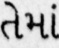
તેમાં
